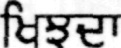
ਖਿਝਦਾ
